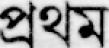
প্রথম
